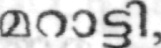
മറാട്ടി,
